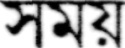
সময়
